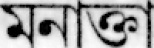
মনাক্তা
